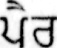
ਪੈਰ
